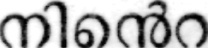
നിന്റെ
